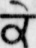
ਕੇ
